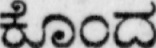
ಕೊಂದ
